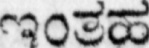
ಇಂತಹ
